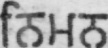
ਨਿਮਨ
